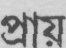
প্ৰায়
